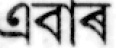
এবাৰ
